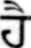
ਹੈ
